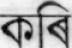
কৰি
